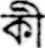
কী
